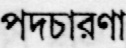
পদচারণা
